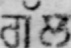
ਗੱਲ
